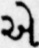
એ
